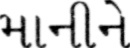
માનીને
